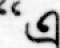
“এ
